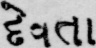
દેવતા
